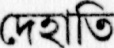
দেহাতি
